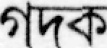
গদক
